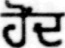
ਹੋਂਦ
